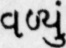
વળ્યું
